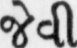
જેવી
